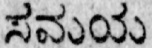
ಸಮಯ
